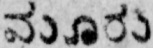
ಮೂರು
